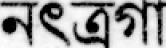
নৎত্রগা
